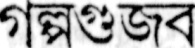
গল্পগুজব
